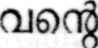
വന്റെ
